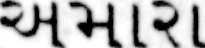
અમારા
